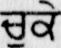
ਚੁਕੇ
